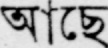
আছে
